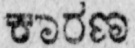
ಕಾರಣ
